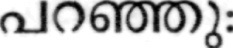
പറഞ്ഞു:
